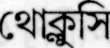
থোক্লুসি
